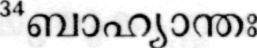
34ബാഹ്യാന്തഃ
